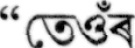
"তেওঁৰ
